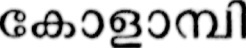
കോളാമ്പി
